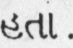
હતા.
